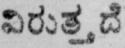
ವಿರುತ್ತದೆ
